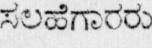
ಸಲಹೆಗಾರರು
